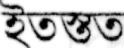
ইতস্তত
